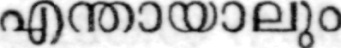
എന്തായാലും
